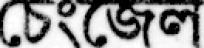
চেংজেল
